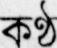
কণ্ঠ
